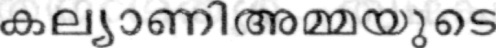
കല്യാണിഅമ്മയുടെ
